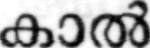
കാല്‍
